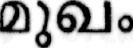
മുഖം
